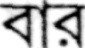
বার
